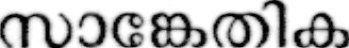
സാങ്കേതിക
